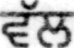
ਵੱਲ
